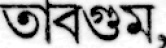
তাবগুম,
